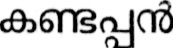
കണ്ടപ്പന്‍
